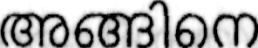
അങ്ങിനെ
